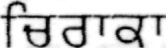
ਚਿਰਾਕਾ
